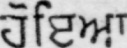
ਹੋਇਆ
